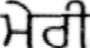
ਮੇਰੀ
